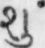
શું
